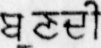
ਬੁਣਦੀ
